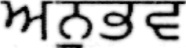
ਅਨੁਭਵ
